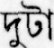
দুটা
